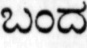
ಬಂದ
